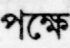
পক্ষে
